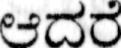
ಆದರೆ
